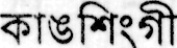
কাঙশিংগী
